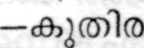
-കുതിര
